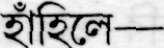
হাঁহিলে-
